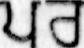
ਪਰ
